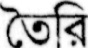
তৈরি
